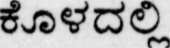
ಕೊಳದಲ್ಲಿ
